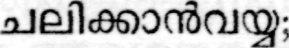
ചലിക്കാന്‍വയ്യ;
